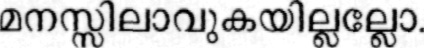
മനസ്സിലാവുകയില്ലല്ലോ.
